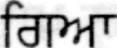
ਗਿਆ
